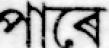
পাৰে
